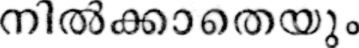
നില്‍ക്കാതെയും
